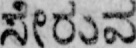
ಸೇರುವ
